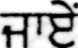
ਜਾਏਂ
